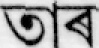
তাৰ
